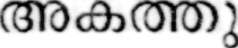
അകത്തു
